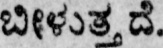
ಬೀಳುತ್ತದೆ.
